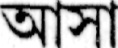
আসা
